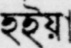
হইয়া
